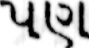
પણ
